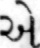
એ
